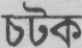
চটক
